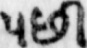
પછી
